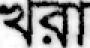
খরা
